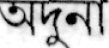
অদুনা
